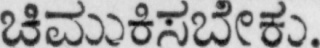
ಚಿಮುಕಿಸಬೇಕು.
